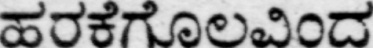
ಹರಕೆಗೊಲವಿಂದ
